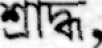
শ্রাদ্ধ,
